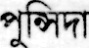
পুন্সিদা
